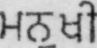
ਮਨੁਖੀ
